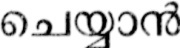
ചെയ്യാന്‍
